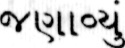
જણાવ્યું
